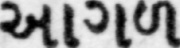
આગળ
